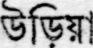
উড়িয়া
